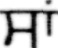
ਸਾਂ
